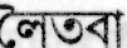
লৈতবা
